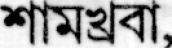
শামখ্রবা,
